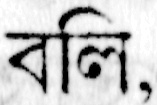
বলি,
